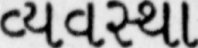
વ્યવસ્થા
